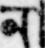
না
